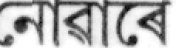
নোৱাৰে
